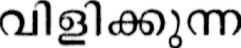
വിളിക്കുന്ന
